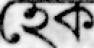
হেক
